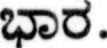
ಭಾರ.
